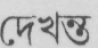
দেখন্ত
